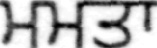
ਮਮਤਾ
